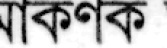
মাকণক
